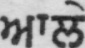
ਆਲੇ
